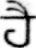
ਹੈ
